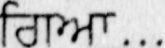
ਗਿਆ...
